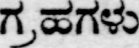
ಗ್ರಹಗಳು
